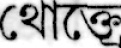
থোক্ত্রে
